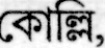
কোল্লি,
